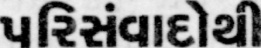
પરિસંવાદોથી
